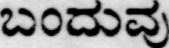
ಬಂದುವು
